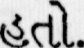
હતો.
